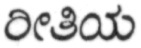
ರೀತಿಯ
